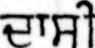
ਦਾਸੀ
